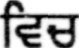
ਵਿਚ
